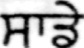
ਸਾਡੇ
